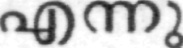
എന്നു
